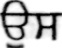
ਉਸ
